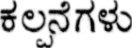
ಕಲ್ಪನೆಗಳು
